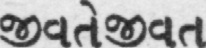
જીવતેજીવત
